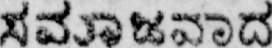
ಸಮಾಜವಾದ
